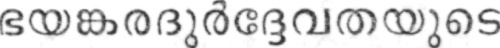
ഭയങ്കരദുര്‍ദ്ദേവതയുടെ
